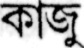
কাজু
